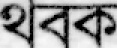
থবক
